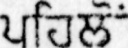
ਪਹਿਲੋਂ
